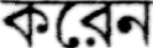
করেন
